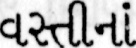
વસ્તીનાં
